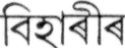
বিহাৰীৰ
